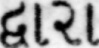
દ્વારા
